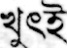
খুৎই
